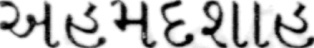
અહમદશાહ
